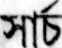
সার্চ
